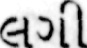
લગી
